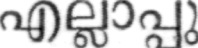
എല്ലാപ്പു
